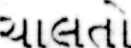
ચાલતો
